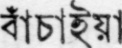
বাঁচাইয়া
